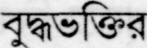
বুদ্ধভক্তির
